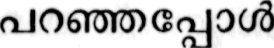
പറഞ്ഞപ്പോള്‍
